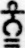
ਨੂੰ
